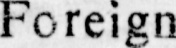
Foreign
